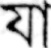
যা
